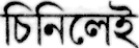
চিনিলেই
